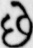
છે
